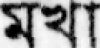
মখা
